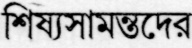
শিষ্যসামন্তদের
